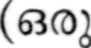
(ഒരു
